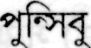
পুন্সিবু
